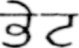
ਭੇਟ
